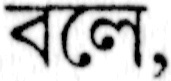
বলে,
